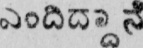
ಎಂದಿದ್ದಾನೆ
